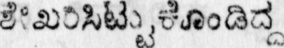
ಶೇಖರಿಸಿಟ್ಟುಕೊಂಡಿದ್ದ
